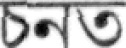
চনত
